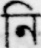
নি
